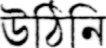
উঠিনি
